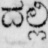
ದಲ್ಲಿ
